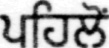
ਪਹਿਲੋਂ
